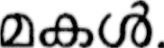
മകള്‍.
